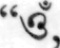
"ওঁ,
